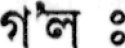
গ'লঃ
